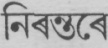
নিৰন্তৰে
